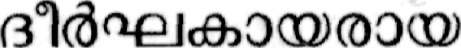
ദീര്‍ഘകായരായ
